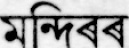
মন্দিৰৰ
